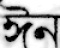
ঈন
